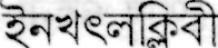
ইনখৎলক্লিবী
